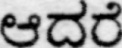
ಆದರೆ
